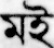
মই
